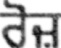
ਰੋਜ਼
